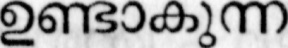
ഉണ്ടാകുന്ന
